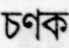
চণক
